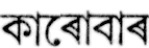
কাৰোবাৰ
